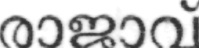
രാജാവ്
